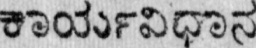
ಕಾರ್ಯವಿಧಾನ
